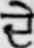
ਦੇ
